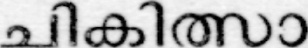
ചികിത്സാ
